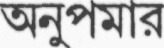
অনুপমার
